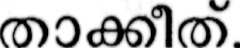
താക്കീത്.
